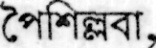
পৈশিল্লবা,
